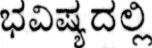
ಭವಿಷ್ಯದಲ್ಲಿ
